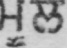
ਮੂਲ
